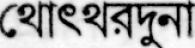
থোৎথরদুনা
